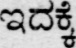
ಇದಕ್ಕೆ
